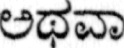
ಅಥವಾ
